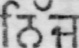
ਨਿੱਜ
